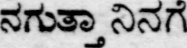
ನಗುತ್ತಾ ನಿನಗೆ
